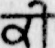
ਕੀ
